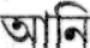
আনি
